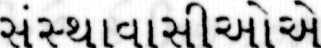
સંસ્થાવાસીઓએ
